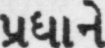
પ્રધાને
